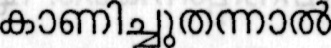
കാണിച്ചുതന്നാല്‍
